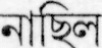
নাছিল
